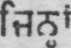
ਜਿਨ੍ਹਾਂ
